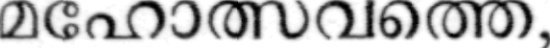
മഹോത്സവത്തെ,
